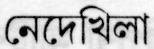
নেদেখিলা
